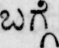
ಬಗ್ಗೆ
